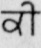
ਕੀ
